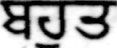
ਬਹੁਤ
